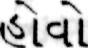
હોવો
